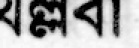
থল্লবা
